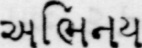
અભિનય
